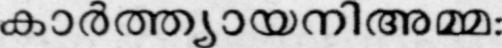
കാര്‍ത്ത്യായനിഅമ്മ:
